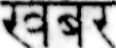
खबर
